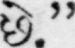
છે."
